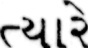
ત્યારે
